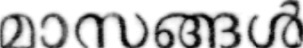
മാസങ്ങള്‍
